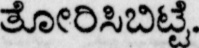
ತೋರಿಸಿಬಿಟ್ಟೆ.
